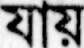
যায়
